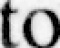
to
